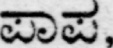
ಪಾಪ,
